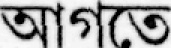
আগতে
